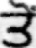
ਤੋਂ
